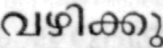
വഴിക്കു
